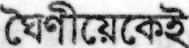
ঘৈণীয়েকেই
